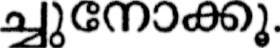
ച്ചുനോക്കൂ.
